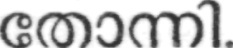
തോന്നി.
